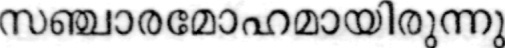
സഞ്ചാരമോഹമായിരുന്നു
